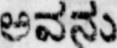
ಅವನು
